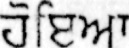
ਹੋਇਆ
